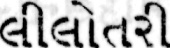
લીલોતરી
